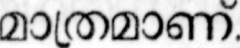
മാത്രമാണ്.
